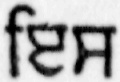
ਇਸ
